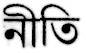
নীতি
